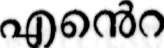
എന്റെ
